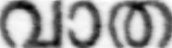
വാത
